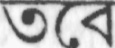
তবে
